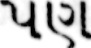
પણ
